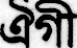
ঐগী
